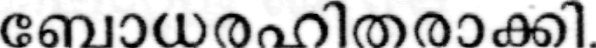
ബോധരഹിതരാക്കി.
